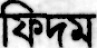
ফিদম
